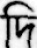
দি
